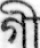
গী
